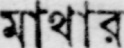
মাথার
